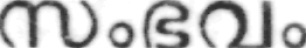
സംഭവം
